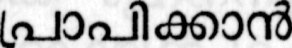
പ്രാപിക്കാന്‍
